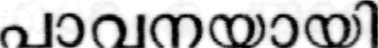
പാവനയായി
